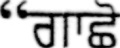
''ਗਾਛੋ
